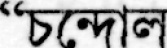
“চন্দোল
